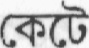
কেটে
